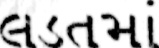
લડતમાં
